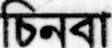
চিনবা
